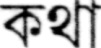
কথা
